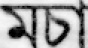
মচা
